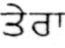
ਤੇਰਾ
